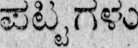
ಪಟ್ಟಿಗಳು
